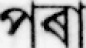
পৰা
